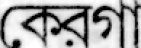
কেরগা
